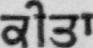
ਕੀਤਾ
